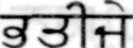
ਭਤੀਜੇ
